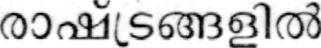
രാഷ്ട്രങ്ങളില്‍
